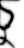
চু
